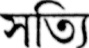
সত্যি
